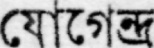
যোগেন্দ্র
